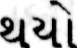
થયો
